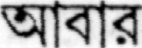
আবার
